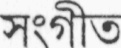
সংগীত
